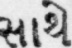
સાથે
